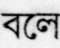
বলে
